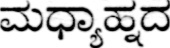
ಮಧ್ಯಾಹ್ನದ
